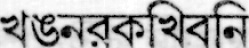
খঙনরকখিবনি
